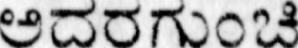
ಅದರಗುಂಚಿ
